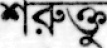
শরুক্তু
